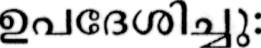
ഉപദേശിച്ചു:
